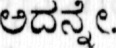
ಅದನ್ನೇ.
